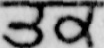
ਤਕ
